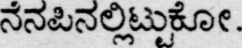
ನೆನಪಿನಲ್ಲಿಟ್ಟುಕೋ.
